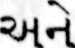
અને
